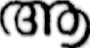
ആ
